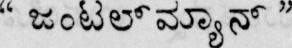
"ಜಂಟಲ್ ಮ್ಯಾನ್"
